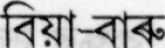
বিয়া-বাৰু
